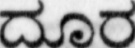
ದೂರ
